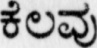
ಕೆಲವು
